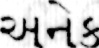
અનેક
